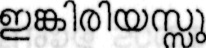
ഇങ്കിരിയസ്സു
